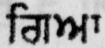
ਗਿਆ
